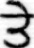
ਤੇ
